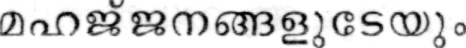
മഹജ്ജനങ്ങളുടേയും
